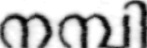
നമ്പി
